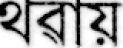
থৱায়
